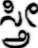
ಸ್ತ್ರೀ
